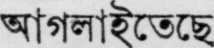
আগলাইতেছে
